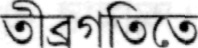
তীব্রগতিতে
